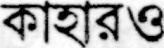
কাহারও
